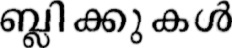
ബ്ലിക്കുകള്‍
